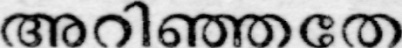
അറിഞ്ഞതേ
